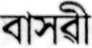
বাসৱী
